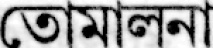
তোমালনা
